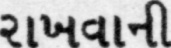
રાખવાની
